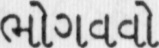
ભોગવવો
